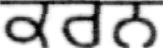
ਕਰਨ
